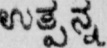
ಉತ್ಪನ್ನ
